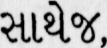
સાથેજ,
